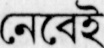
নেবেই
